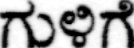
ಗುಳಿಗೆ
